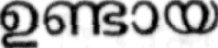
ഉണ്ടായ
